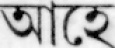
আহে
